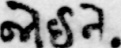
જોઈને.
